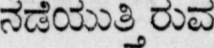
ನಡೆಯುತ್ತಿರುವ
